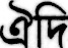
ঐদি
